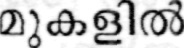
മുകളില്‍
